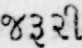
જરૂરી
